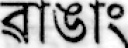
ৱাঙাং
